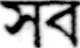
সব
